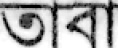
তাবা
